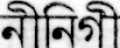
নীনিগী
